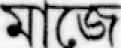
মাজে
